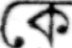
কে
